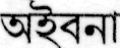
অইবনা
